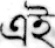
এই
